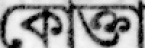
কোক্তা
